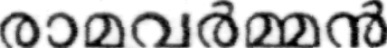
രാമവര്‍മ്മന്‍
